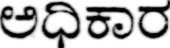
ಅಧಿಕಾರ
